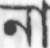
না
